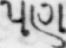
પણ
